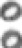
ঃ
